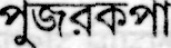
পুজরকপা
